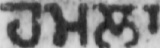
ਹਮਲਾ
